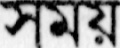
সময়
